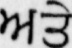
ਅਤੇ
